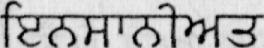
ਇਨਸਾਨੀਅਤ
